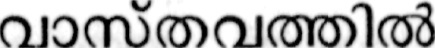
വാസ്തവത്തില്‍
